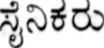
ಸೈನಿಕರು
